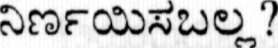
ನಿರ್ಣಯಿಸಬಲ್ಲ?
